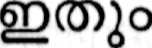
ഇതും
